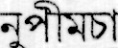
নুপীমচা
